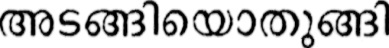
അടങ്ങിയൊതുങ്ങി
